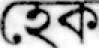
হেক
